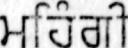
ਮਹਿੰਗੀ
